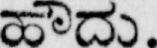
ಹೌದು.
